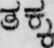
ತಕ್ಕ
